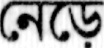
নেড়ে
